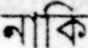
নাকি
